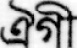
ঐগী
